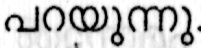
പറയുന്നു.
